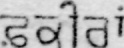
ਫ਼ਕੀਰਾਂ
